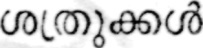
ശത്രുക്കള്‍
